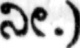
ನೀ)
